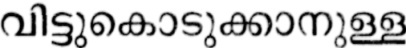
വിട്ടുകൊടുക്കാനുള്ള
